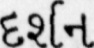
દર્શન
